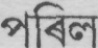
পৰিল
